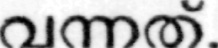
വന്നത്.
